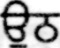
ਉਠ
